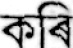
কৰি
